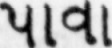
પાવા
